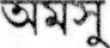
অমসু
